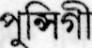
পুন্সিগী
